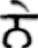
ਨੇ
